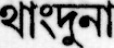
থাংদুনা
